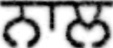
ਨਾਲ
